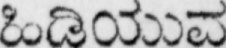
ಹಿಡಿಯುವ
